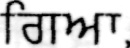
ਗਿਆ,
